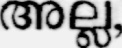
അല്ല,
